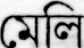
মেলি
